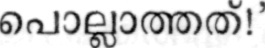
പൊല്ലാത്തത്!'
